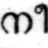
നീ
